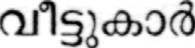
വീട്ടുകാര്‍
